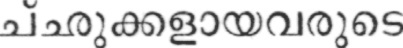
ച്ഛുക്കളായവരുടെ
